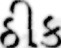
ઠીક
